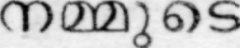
നമ്മുടെ
